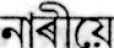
নাৰীয়ে
